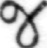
જ
